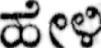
ಹೇಳಿ
